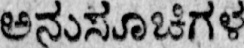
ಅನುಸೂಚಿಗಳ
